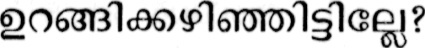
ഉറങ്ങിക്കഴിഞ്ഞിട്ടില്ലേ?
